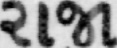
રાજા
